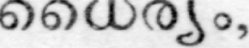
ധൈര്യം,
